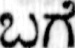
ಬಗೆ
